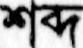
শব্দ
